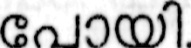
പോയി.
